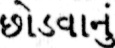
છોડવાનું
